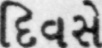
દિવસે
